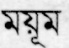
ময়ুম
